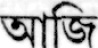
আজি
